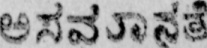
ಅಸಮಾನತೆ
